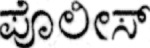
ಪೊಲೀಸ್
